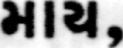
માય,
